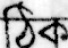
ঠিক
